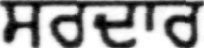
ਸਰਦਾਰ
